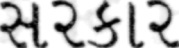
સરકાર
